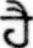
ਹੈ
